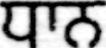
ਧਾਨ
